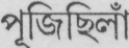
পূজিছিলাঁ
